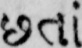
છતાં
